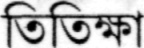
তিতিক্ষা
